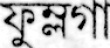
ফুম্লগা
